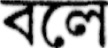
বলে
